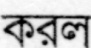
করল
